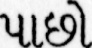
પાછો
